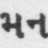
મન
